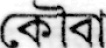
কৌবা
